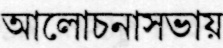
আলোচনাসভায়
